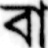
বা
